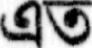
এত
